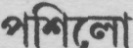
পশিলো
